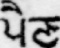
ਪੈਣ
